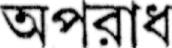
অপরাধ
